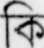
কি
